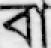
বা
